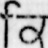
ਕਿ
